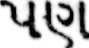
પણ
